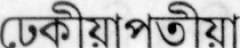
ঢেকীয়াপতীয়া
